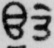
ਉਤੇ
